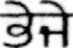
ਭੇਜੇ
